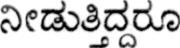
ನೀಡುತ್ತಿದ್ದರೂ
